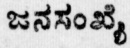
ಜನಸಂಖ್ಯೆ
